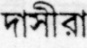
দাসীরা
